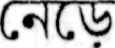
নেড়ে
